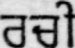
ਰਚੀ
